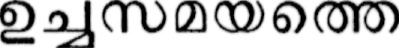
ഉച്ചസമയത്തെ
